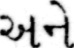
અને
